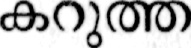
കറുത്ത
